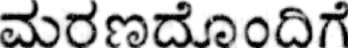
ಮರಣದೊಂದಿಗೆ
